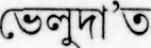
ভেলুদা'ত
